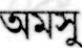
অমসু
